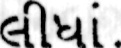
લીધાં.
